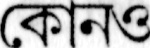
কোনও
